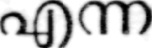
എന്ന
